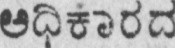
ಅಧಿಕಾರದ
